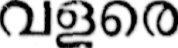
വളരെ
